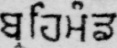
ਬ੍ਰਹਿਮੰਡ
